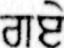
ਗਏ
